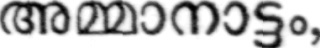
അമ്മാനാട്ടം,
